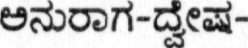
ಅನುರಾಗ-ದ್ವೇಷ-
